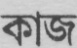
কাজ
